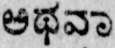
ಅಥವಾ
